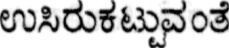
ಉಸಿರುಕಟ್ಟುವಂತೆ
